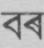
বৰ
